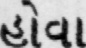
હોવા
